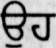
ਉਹ
